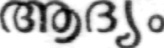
ആദ്യം
